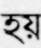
হয়
